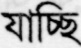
যাচ্ছি
